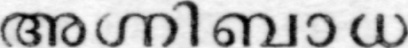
അഗ്നിബാധ
